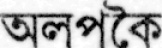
অলপকৈ
